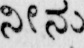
ನೀನು
